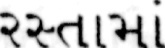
રસ્તામાં
